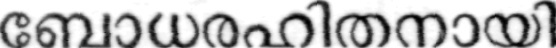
ബോധരഹിതനായി
